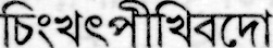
চিংখৎপীখিবদো
